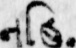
નહિ.
